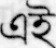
এই
